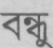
বন্ধু
